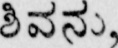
ಶಿವನು,
